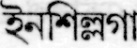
ইনশিল্লগা
